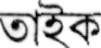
তাইক
